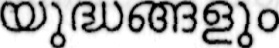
യുദ്ധങ്ങളും
